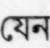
যেন
